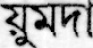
য়ুমদা
